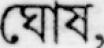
ঘোষ,
